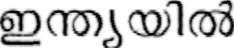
ഇന്ത്യയില്‍
